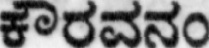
ಕೌರವನಂ
